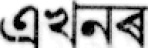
এখনৰ
